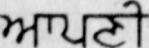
ਆਪਣੀ
